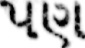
પણ
